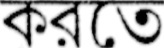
করতে
